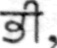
ਭੀ,
